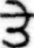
ਤੇ
